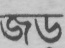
জড়
